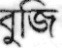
বুজি
